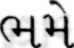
ભમે
